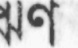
ঋণ
